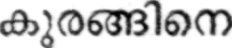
കുരങ്ങിനെ
